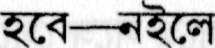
হবে–নইলে
